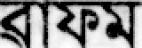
ৱাফম
